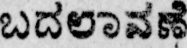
ಬದಲಾವಣೆ
